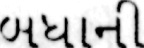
બધાની
